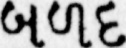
બળદ
